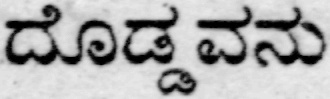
ದೊಡ್ಡವನು
